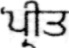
'ਪ੍ਰੀਤ
